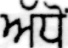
ਅੱਧੋਂ
